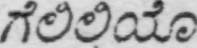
ಗೆಲಿಲಿಯೊ
